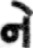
ને
